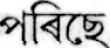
পৰিছে
